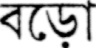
বড়ো
